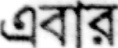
এবার
